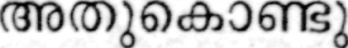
അതുകൊണ്ടു
